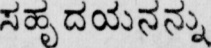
ಸಹೃದಯನನ್ನು
